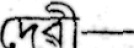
দেৱী-
